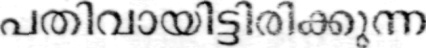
പതിവായിട്ടിരിക്കുന്ന
